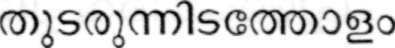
തുടരുന്നിടത്തോളം
